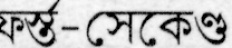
ফর্স্ত-সেকেণ্ড
